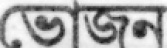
ভোজন
